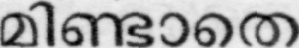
മിണ്ടാതെ
